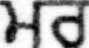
ਮਰ
